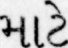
માટે
